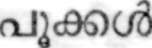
പൂക്കള്‍
